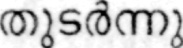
തുടര്‍ന്നു
